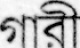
গারী
